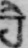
ਹੈ
